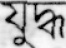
যুদ্ধ
